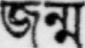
জন্ম
